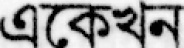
একেখন
